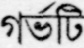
গর্ভটি
